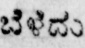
ಬೆಳೆದು
